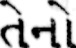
તેનો
